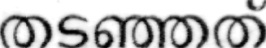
തടഞ്ഞത്
